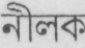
নীলক
